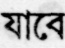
যাবে
